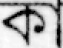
কা
